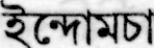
ইন্দোমচা
